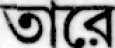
তারে
